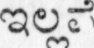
ಇಲ್ಲವೆ
